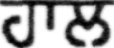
ਹਾਲ
